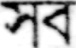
সব
